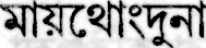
মায়থোংদুনা
